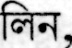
লিন,
